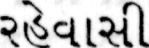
રહેવાસી
